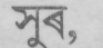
সুৰ,
